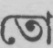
তো
